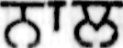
ਨਾਲ
